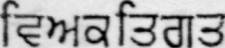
ਵਿਅਕਤਿਗਤ
